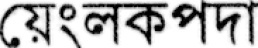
য়েংলকপদা
